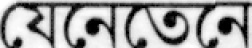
যেনেতেনে
